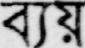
ব্যয়
